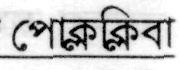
পোক্লক্লিবা
